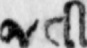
જતી
